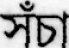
সঁচা
